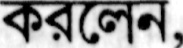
করলেন,
